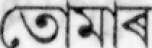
তোমাৰ
